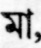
মা,
